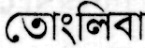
তোংলিবা
